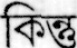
কিন্তু
